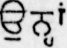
ਉਨ੍ਹਾਂ
